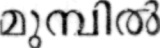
മുമ്പില്‍
